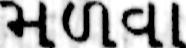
મળવા
